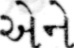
એને
